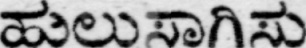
ಹುಲುಸಾಗಿಸು
